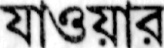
যাওয়ার
